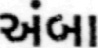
અંબા
